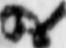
જ
